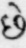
છે
